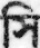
সি
